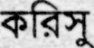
করিসু
